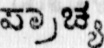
ಪ್ರಾಚ್ಯ
